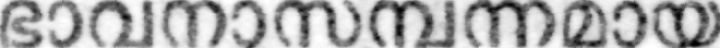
ഭാവനാസമ്പന്നമായ
